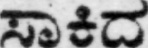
ಸಾಕಿದ
